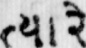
ત્યારે
